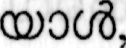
യാള്‍,
